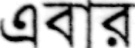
এবার
